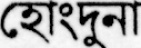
হোংদুনা
